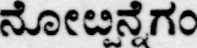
ನೋೞ್ಪನ್ನೆಗಂ
